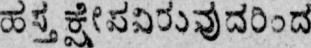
ಹಸ್ತಕ್ಷೇಪವಿರುವುದರಿಂದ
